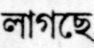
লাগছে
